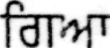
ਗਿਆ
